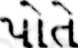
પોતે
